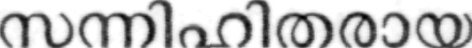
സന്നിഹിതരായ
